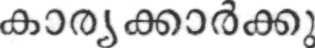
കാര്യക്കാര്‍ക്കു
